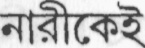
নারীকেই
